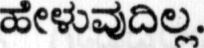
ಹೇಳುವುದಿಲ್ಲ.
